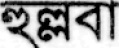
হুল্লবা
